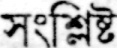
সংশ্লিষ্ট
